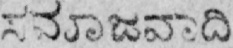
ಸಮಾಜವಾದಿ
